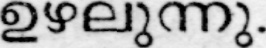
ഉഴലുന്നു.
